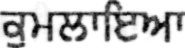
ਕੁਮਲਾਇਆ
